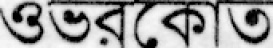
ওভরকোত
